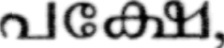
പക്ഷേ,
